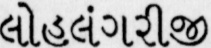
લોહલંગરીજી
